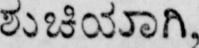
ಶುಚಿಯಾಗಿ,
